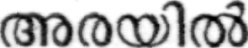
അരയില്‍
